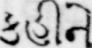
કહીને
